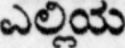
ಎಲ್ಲಿಯ
